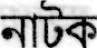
নাটক
